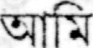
আমি
